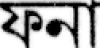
ফনা
